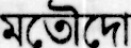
মতৌদা
